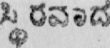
ಸ್ಥಿರವಾದ
